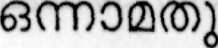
ഒന്നാമതു
